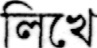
লিখে
